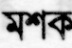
মশক
